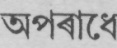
অপৰাধে
